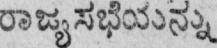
ರಾಜ್ಯಸಭೆಯನ್ನು
